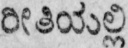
ರೀತಿಯಲ್ಲಿ
